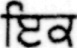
ਇਕ
